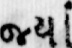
જ્યાં
